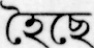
হৈছে
